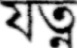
যত্ন
